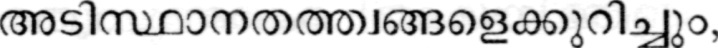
അടിസ്ഥാനതത്ത്വങ്ങളെക്കുറിച്ചും,
